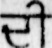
ਦੀ
